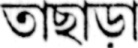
তাছাড়া
